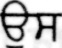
ਉਸ
